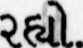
રહ્યો.
